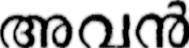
അവന്‍
